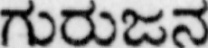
ಗುರುಜನ
